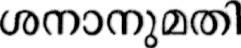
ശനാനുമതി
